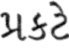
પ્રકટે
